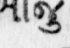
બીજું
